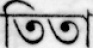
তিতা
